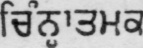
ਚਿੰਨ੍ਹਾਤਮਕ
